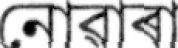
নোৱাৰা
